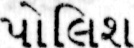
પોલિશ
